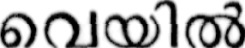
വെയില്‍
